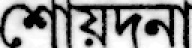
শোয়দনা
